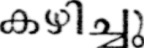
കഴിച്ചു
